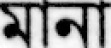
মানা
